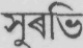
সুৰভি
